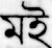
মই
